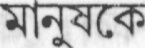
মানুষকে
